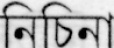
নিচিনা
